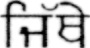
ਜਿੱਥੇ
